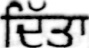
ਦਿੱਤਾ
